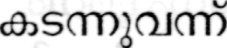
കടന്നുവന്ന്
